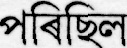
পৰিছিল
